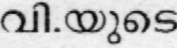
വി.യുടെ
